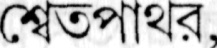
শ্বেতপাথর,
